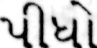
પીધો
